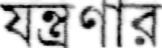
যন্ত্রণার
